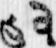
હવે
